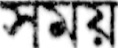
সময়
